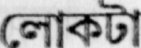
লোকটা
